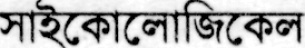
সাইকোলোজিকেল
